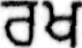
ਰਖ
